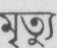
মৃত্যু
